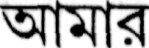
আমার
